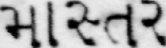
માસ્તર
